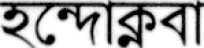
হন্দোক্নবা
